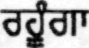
ਰਹੂੰਗਾ
